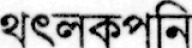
থৎলকপনি
